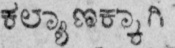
ಕಲ್ಯಾಣಕ್ಕಾಗಿ
